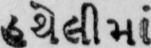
હથેલીમાં
